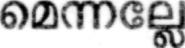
മെന്നല്ലേ
